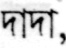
দাদা,
